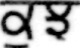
ਕੁਝ
